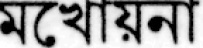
মখোয়না
